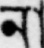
না
